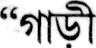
"গাড়ী
